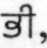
ਭੀ,
